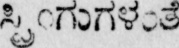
ಸ್ಟ್ರಿಂಗುಗಳಂತೆ
